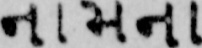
નામના
